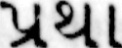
પ્રથા
